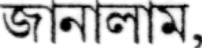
জানালাম,
